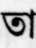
তা
